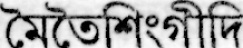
মৈতৈশিংগীদি
